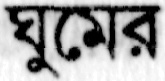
ঘুমের
